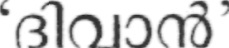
'ദിവാന്‍'
